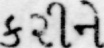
કરીને
